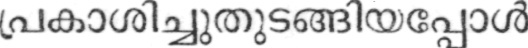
പ്രകാശിച്ചുതുടങ്ങിയപ്പോള്‍
